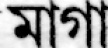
মাগা
